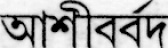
আশীর্ব্বদ
